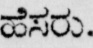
ಹೆಸರು.
